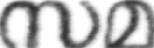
സമ
